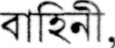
বাহিনী,
